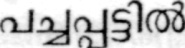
പച്ചപ്പട്ടില്‍
